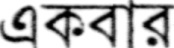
একবার
